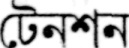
টেনশন
